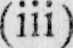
(iii)
